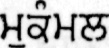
ਮੁਕੰਮਲ
